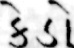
કેડો
